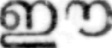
ഈ
